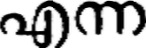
എന്ന
